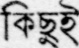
কিছুই
